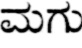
ಮಗು
